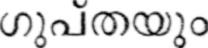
ഗുപ്തയും
